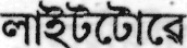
লাইটটোৱে
